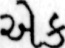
એક
